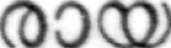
രായ
